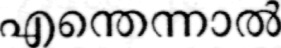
എന്തെന്നാല്‍
